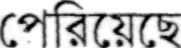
পেরিয়েছে
